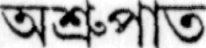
অশ্রুপাত
